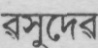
ৱসুদেৱ
